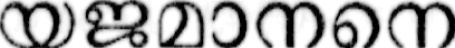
യജമാനനെ
